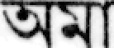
অমা
